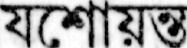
যশোয়ন্ত
